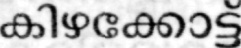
കിഴക്കോട്ട്
